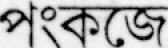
পংকজে
